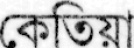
কেতিয়া
